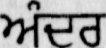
ਅੰਦਰ
